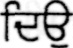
ਦਿਉ
